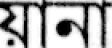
য়ানা
